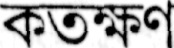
কতক্ষণ
